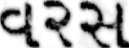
વરસ
